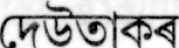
দেউতাকৰ
